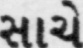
સાચે
